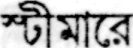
স্টীমারে
